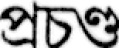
প্রচণ্ড
